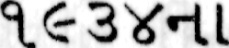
૧૯૩૪ના
